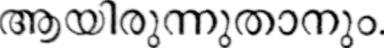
ആയിരുന്നുതാനും.
